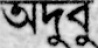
অদুবু
